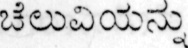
ಚೆಲುವಿಯನ್ನು
